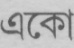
একো
